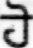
ਹੋ
